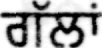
ਗੱਲਾਂ
